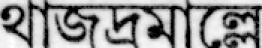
থাজদ্রমাল্লে
